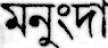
মনুংদা
